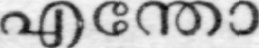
എന്തോ
